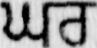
ਘਰ
